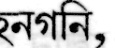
হনগনি,
